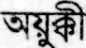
অয়ুক্কী
